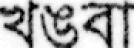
খঙবা
